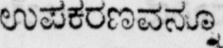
ಉಪಕರಣವನ್ನೂ
